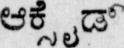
ಆಕ್ಸೈಡ್
